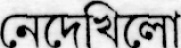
নেদেখিলো
